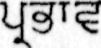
ਪ੍ਰਭਾਵ
